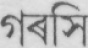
গৰসি
